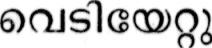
വെടിയേറ്റു
